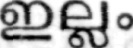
ഇല്ലം
